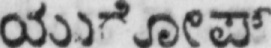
ಯುರೋಪ್
